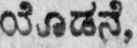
ಯೊಡನೆ,
